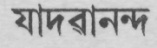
যাদৱানন্দ
